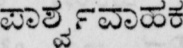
ಪಾರ್ಶ್ವವಾಹಕ
